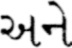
અને
